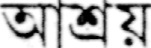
আশ্রয়
